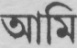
আমি
